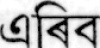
এৰিব
